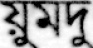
য়ুমদু
